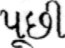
પૂછી
